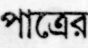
পাত্রের
